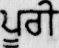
ਪੂਰੀ
